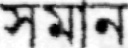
সমান
